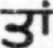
ਤਾਂ
